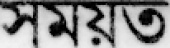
সময়ত
